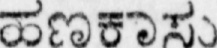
ಹಣಕಾಸು
